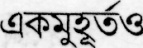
একমুহূর্তও
